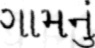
ગામનું
